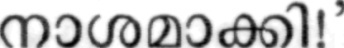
നാശമാക്കി!'
